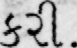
કરી.
